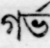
গর্ভ
